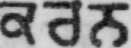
ਕਰਨ
